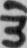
ਤੇ
